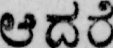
ಆದರೆ
